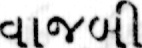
વાજબી
